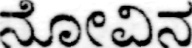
ನೋವಿನ
